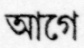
আগে
